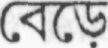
বেড়ে
